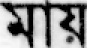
মায়
